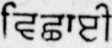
ਵਿਛਾਈ
